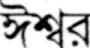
ঈশ্বর
